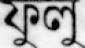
ফুলু
